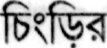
চিংড়ির
